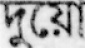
দুয়ো
